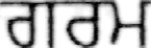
ਗਰਮ
